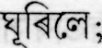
ঘূৰিলে;
